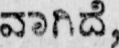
ವಾಗಿದೆ,
